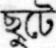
ছুটে
